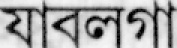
যাবলগা
